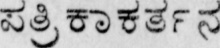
ಪತ್ರಿಕಾಕರ್ತನ
